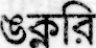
ঙক্নরি
